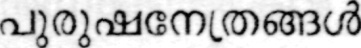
പുരുഷനേത്രങ്ങള്‍
